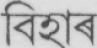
বিহাৰ
